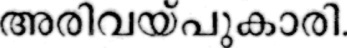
അരിവയ്പുകാരി.
